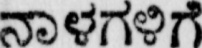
ನಾಳಗಳಿಗೆ
